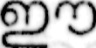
ഈ
